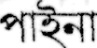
পাইনা
